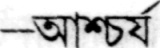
-আশ্চর্য
